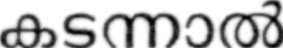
കടന്നാല്‍
